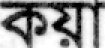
কয়া
